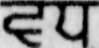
ਵਧ
